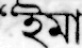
“ইমা
